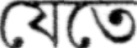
যেতে
